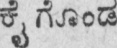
ಕೈಗೊಂಡ
